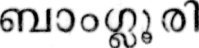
ബാംഗ്ലൂരി
